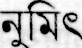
নুমিৎ
